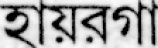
হায়রগা
